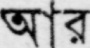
আর
